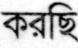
করছি
